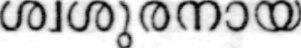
ശ്വശുരനായ
